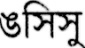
ঙসিসু
